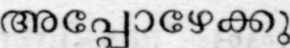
അപ്പോഴേക്കു
